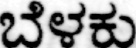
ಬೆಳಕು
